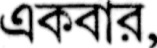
একবার,
